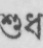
শুধ
